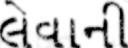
લેવાની
